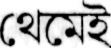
থেমেই
